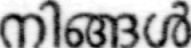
നിങ്ങള്‍
